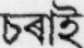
চৰাই
